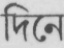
দিনে
